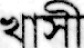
খাসী
